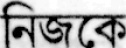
নিজকে
